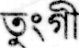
তুংগী
